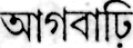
আগবাঢ়ি
